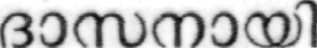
ദാസനായി
